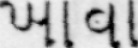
ખાવા
